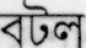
বটল
